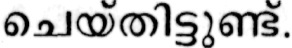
ചെയ്തിട്ടുണ്ട്.
